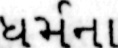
ધર્મના
